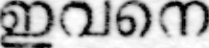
ഇവനെ
